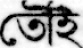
তৌই
